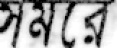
সমরে
